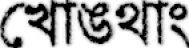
খোঙথাং
